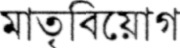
মাতৃবিয়োগ
